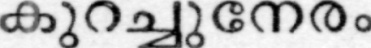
കുറച്ചുനേരം
